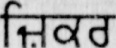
ਜ਼ਿਕਰ
